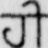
ਹੀ
